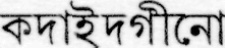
কদাইদগীনো
